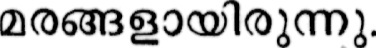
മരങ്ങളായിരുന്നു.
